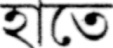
হাতে
